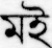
মই
